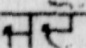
ਜਦੋਂ
